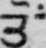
ਤੋਂ
